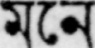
মনে
